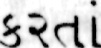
કરતાં
